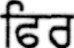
ਫਿਰ
